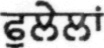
ਫੁਲੇਲਾਂ
